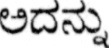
ಅದನ್ನು
